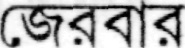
জেরবার
